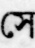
সে
